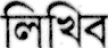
লিখিব
